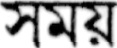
সময়
